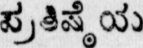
ಪ್ರತಿಷ್ಠೆಯ
